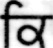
ਕਿ
